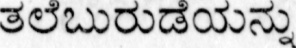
ತಲೆಬುರುಡೆಯನ್ನು
